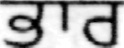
ਭਾਰ
